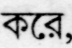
করে,
